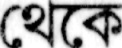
থেকে
